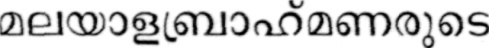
മലയാളബ്രാഹ്മണരുടെ
